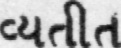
વ્યતીત
